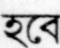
হবে
